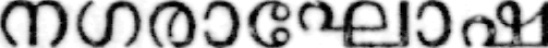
നഗരാഘോഷ
